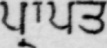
ਪ੍ਰਾਪਤ
